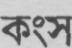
কংস
